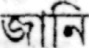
জানি
